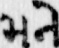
મને
